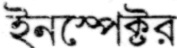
ইনস্পেক্টর
